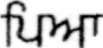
ਪਿਆ
